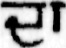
ਦਾ
